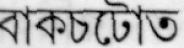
বাকচটোত
